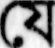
যে
